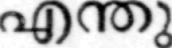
എന്തു
